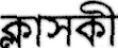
ক্লাসকী
